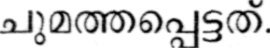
ചുമത്തപ്പെട്ടത്.
